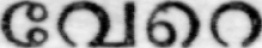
വേറെ
